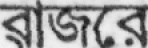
ৱাজরে
